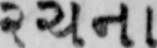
રચના
